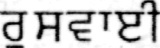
ਰੁਸਵਾਈ
